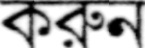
করুন
